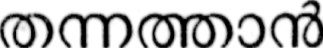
തന്നത്താന്‍
